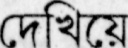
দেখিয়ে
